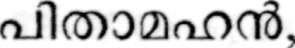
പിതാമഹന്‍,
